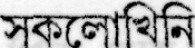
সকলোখিনি
